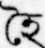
হৈ
